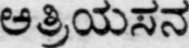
ಅತ್ರಿಯಸನ
